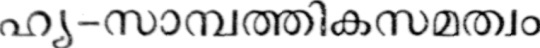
ഹ്യ-സാമ്പത്തികസമത്വം
